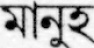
মানুহ
